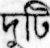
দুটি
